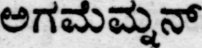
ಅಗಮೆಮ್ನನ್
